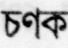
চণক
